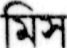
মিস
